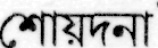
শোয়দনা
